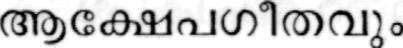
ആക്ഷേപഗീതവും
